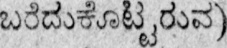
ಬರೆದುಕೊಟ್ಟಿರುವ)
